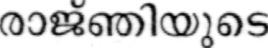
രാജ്ഞിയുടെ
